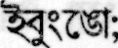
ইবুংঙো;
